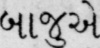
બાજુએ
